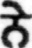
ਨੇ
